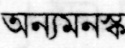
অন্যমনস্ক
